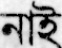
নাই
